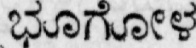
ಭೂಗೋಳ
